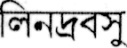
লিনদ্রবসু
